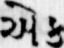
એક
